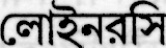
লোইনরসি
